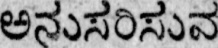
ಅನುಸರಿಸುವ
